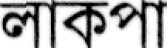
লাকপা
